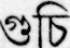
গুচি
